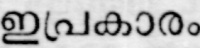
ഇപ്രകാരം
